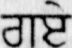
ਗਏ
